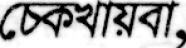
চেকখায়বা,
